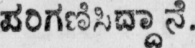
ಪರಿಗಣಿಸಿದ್ದಾನೆ.
